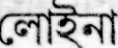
লোইনা
